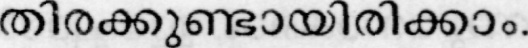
തിരക്കുണ്ടായിരിക്കാം.
